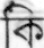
কি
